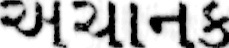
અચાનક
